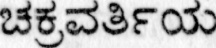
ಚಕ್ರವರ್ತಿಯ
